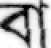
বা
